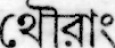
থৌরাং
